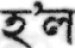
হ'ল
